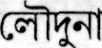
লৌদুনা
